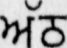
ਅੱਠ
